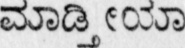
ಮಾಡ್ತೀಯಾ
